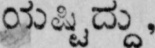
ಯಷ್ಟಿದ್ದು,
